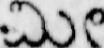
ಮೀ
